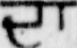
ਦਾ
